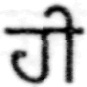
ਹੀ
